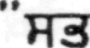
''ਸਭ
